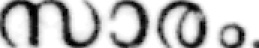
സാരം.
